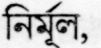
নির্মূল,
